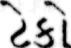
ટેકો
